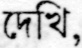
দেখি,
